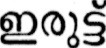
ഇരുട്ട്
